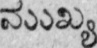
ಮುಖ್ಯ
